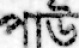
পাউ
